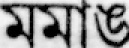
মমাঙ
